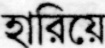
হারিয়ে
